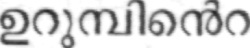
ഉറുമ്പിന്റെ
